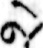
જે
